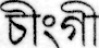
চীংগী
